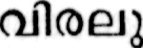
വിരലു
